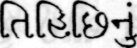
તિહિછિનું
